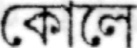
কোলে
